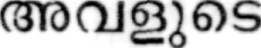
അവളുടെ
